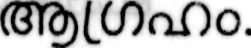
ആഗ്രഹം.
